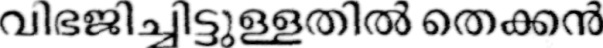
വിഭജിച്ചിട്ടുള്ളതില്‍തെക്കന്‍
